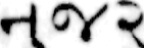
નજર
